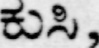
ಕುಸಿ,
